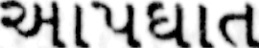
આપઘાત
